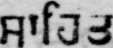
ਸਾਹਿਤ
